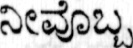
ನೀವೊಬ್ಬ
